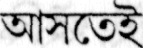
আসতেই
